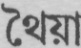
থৈয়া
